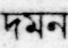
দমন
